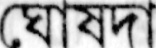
ঘোষদা
